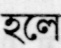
হলে
